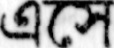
এসে
